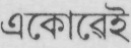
একোৱেই
